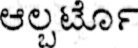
ಆಲ್ಬರ್ಟೊ
